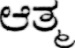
ಆತ್ಮ
